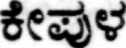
ಕೇಪುಳ
